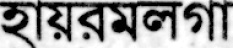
হায়রমলগা
